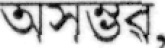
অসম্ভৱ,
